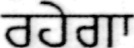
ਰਹੇਗਾ
